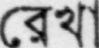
রেখা
